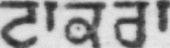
ਟਾਕਰਾ
